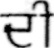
ਦੀ
